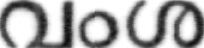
വംശ
